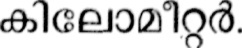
കിലോമീറ്റര്‍.
